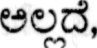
ಅಲ್ಲದೆ,
